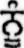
ਨੂੰ
